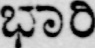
ಭಾರಿ
